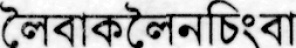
লৈবাকলৈনচিংবা
